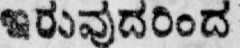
ಇರುವುದರಿಂದ
